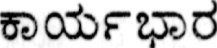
ಕಾರ್ಯಭಾರ
